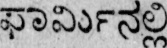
ಫಾರ್ಮಿನಲ್ಲಿ
